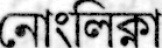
নোংলিক্না
